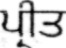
ਪ੍ਰੀਤ
